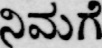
ನಿಮಗೆ
